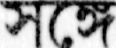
সঙ্গে
